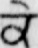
ਕੇ
